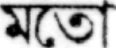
মতো
